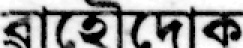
ৱাহৌদোক
